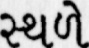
સ્થળે
